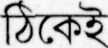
ঠিকেই
